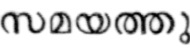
സമയത്തു
